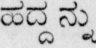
ಹದ್ದನ್ನು
